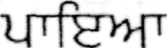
ਪਾਇਆ
